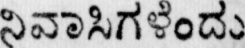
ನಿವಾಸಿಗಳೆಂದು
